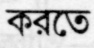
করতে
